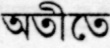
অতীতে
